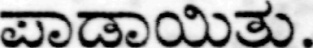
ಪಾಡಾಯಿತು.
